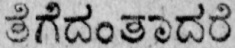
ತೆಗೆದಂತಾದರೆ
